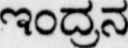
ಇಂದ್ರನ
